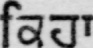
ਕਿਹਾ
